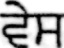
ਵੇਸ
